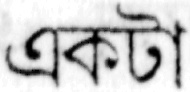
একটা
